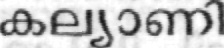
കല്യാണി
